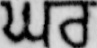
ਘਰ
